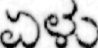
ಏಳು
